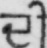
ਦੀ
